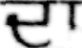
ਦਾ
